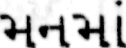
મનમાં
